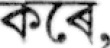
কৰে,
